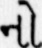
નો
